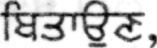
ਬਿਤਾਉਣ,
